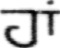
ਹਾਂ
